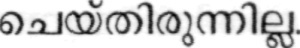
ചെയ്തിരുന്നില്ല.
